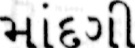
માંદગી
